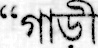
“গাড়ী
